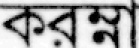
করম্না
